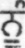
ਨੂੰ
